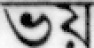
ভয়
